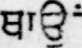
ਥਾਉਂ
